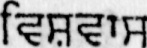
ਵਿਸ਼ਵਾਸ
